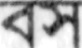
বস
